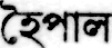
হৈপাল
